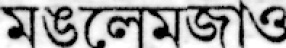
মঙলেমজাও
